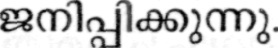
ജനിപ്പിക്കുന്നു.
